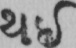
થઈ
